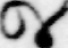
જ
